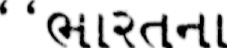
"ભારતના
